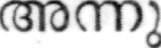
അന്നു
